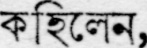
কহিলেন,
